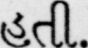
હતી.
